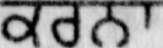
ਕਰਨਾ
